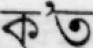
ক'ত
